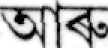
আৰু
